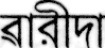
ৱারীদা
